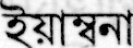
ইয়াম্বনা
